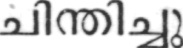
ചിന്തിച്ചു
